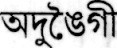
অদুঙৈগী
